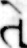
તે
